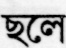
ছলে
